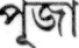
পূজা
